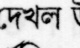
দেখল
